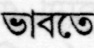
ভাবতে
